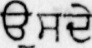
ਉਸਦੇ
